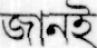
জানই
